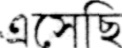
এসেছি
